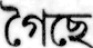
গৈছে
